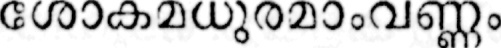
ശോകമധുരമാംവണ്ണം
